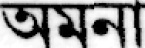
অমনা
